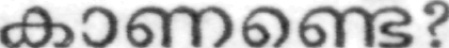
കാണണ്ടെ?
